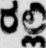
ರಲ್ಲಿ
